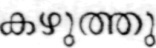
കഴുത്തു
